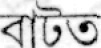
বাটত
